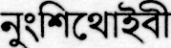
নুংশিথোইবী
